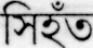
সিহঁত
